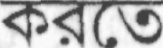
করতে
